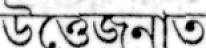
উত্তেজনাত
